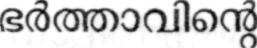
ഭര്‍ത്താവിന്റെ
